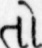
તો
